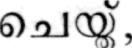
ചെയ്ത്,
